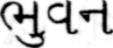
ભુવન
